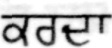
ਕਰਦਾ
